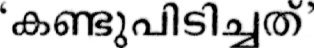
‘കണ്ടുപിടിച്ചത്’
